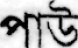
পাউ
